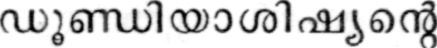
ഡൂണ്ഡിയാശിഷ്യന്റെ
